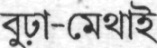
বুঢ়া-মেথাই
